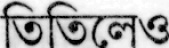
তিতিলেও
